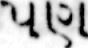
પણ
